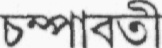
চম্পাবতী
